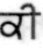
ਕੀ
